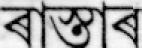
ৰাস্তাৰ
